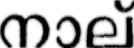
നാല്
